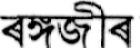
ৰঙ্গজীৰ
